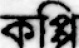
কপ্পি
